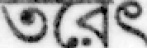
তরেৎ
